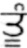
ਤੂੰ
